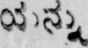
ಯನ್ನು
